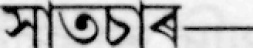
সাতচাৰ-
